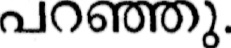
പറഞ്ഞു.
